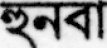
হুনবা
